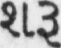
શરૂ
